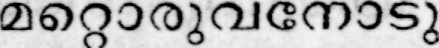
മറ്റൊരുവനോടു
